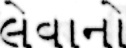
લેવાનો
